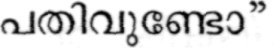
പതിവുണ്ടോ”
